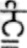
ਨੂੰ
